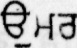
ਉਮਰ
